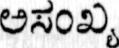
ಅಸಂಖ್ಯ
